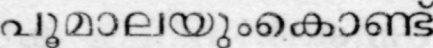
പൂമാലയുംകൊണ്ട്
